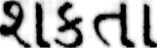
શકતા
